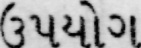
ઉપયોગ
